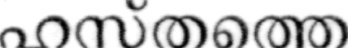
ഹസ്തത്തെ
